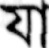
যা
